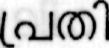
പ്രതി
